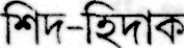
শিদ-হিদাক
